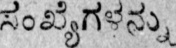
ಸಂಖ್ಯೆಗಳನ್ನು
